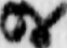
જ
